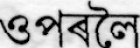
ওপৰলৈ
